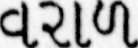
વરાળ
